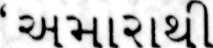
'અમારાથી
